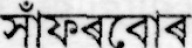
সাঁফৰবোৰ
